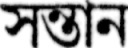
সন্তান
